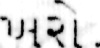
ખરો.
